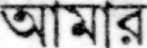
আমার
